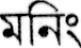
মনিং
